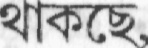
থাকছে,
